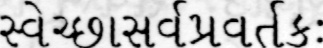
સ્વેચ્છાસર્વપ્રવર્તકઃ
